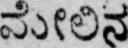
ಮೇಲಿನ
